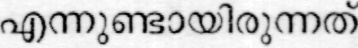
എന്നുണ്ടായിരുന്നത്
